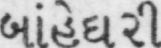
બાંહેધરી
